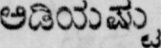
ಅಡಿಯಷ್ಟು
